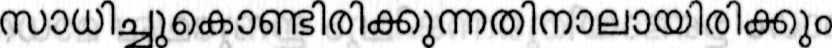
സാധിച്ചുകൊണ്ടിരിക്കുന്നതിനാലായിരിക്കും
